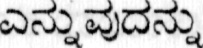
ಎನ್ನುವುದನ್ನು
